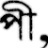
পী,
